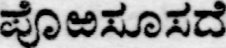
ಪೊಱಸೂಸದೆ
